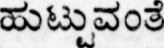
ಹುಟ್ಟುವಂತೆ
